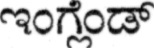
ಇಂಗ್ಲೆಂಡ್
